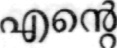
എന്റെ
